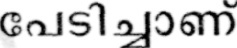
പേടിച്ചാണ്
